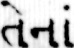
તેનાં
